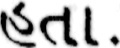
હતા.
